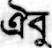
ঐবু
